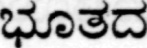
ಭೂತದ
